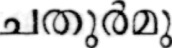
ചതുര്‍മു
